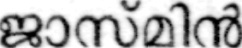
ജാസ്മിന്‍
